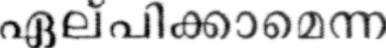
ഏല്പിക്കാമെന്ന
